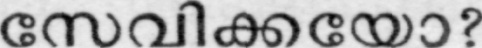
സേവിക്കയോ?
